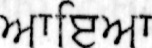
ਆਇਆ
